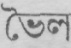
ভৈল
